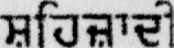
ਸ਼ਹਿਜ਼ਾਦੀ
